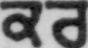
ਕਰ
